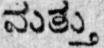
ಮತ್ತು
